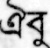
ঐবু
